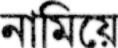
নামিয়ে
